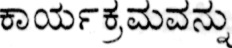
ಕಾರ್ಯಕ್ರಮವನ್ನು
